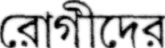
রোগীদের
